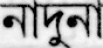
নাদুনা
